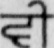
ਵੀ
